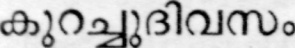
കുറച്ചുദിവസം
